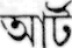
আৰ্ট
